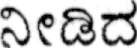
ನೀಡಿದ
